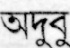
অদুবু
